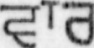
ਵਾਰ
